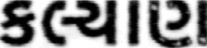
કલ્યાણ
